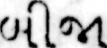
બીજા
